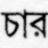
চার
